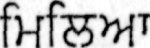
ਮਿਲਿਆ
